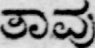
ತಾವು
